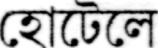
হোটেলে
